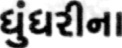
ધુંધરીના
